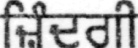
ਜ਼ਿੰਦਗੀ
